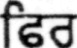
ਫਿਰ
